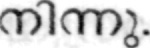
നിന്നു.
